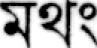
মথং
